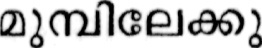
മുമ്പിലേക്കു
